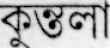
কুন্তলা
